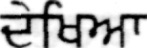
ਦੇਖਿਆ
